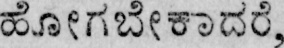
ಹೋಗಬೇಕಾದರೆ,
